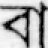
বা
